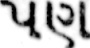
પણ
